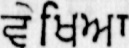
ਵੇਖਿਆ
